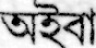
অইবা
